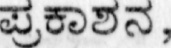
ಪ್ರಕಾಶನ,
